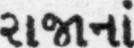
રાજાનાં
